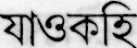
যাওকহি
